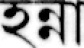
হন্না
